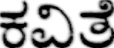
ಕವಿತೆ
